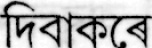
দিবাকৰে
